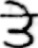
ਤੇ
